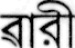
ৱারী
